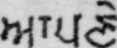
ਆਪਣੇ
